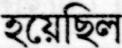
হয়েছিল
